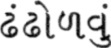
ઢંઢોળવું
